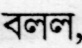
বলল,
